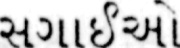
સગાઈઓ
